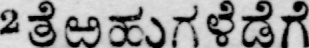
2ತೆಱಹುಗಳೆಡೆಗೆ
